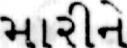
મારીને
